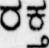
ರಕ್ತ
